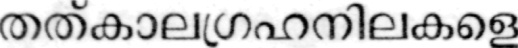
തത്കാലഗ്രഹനിലകളെ
